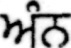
ਅੰਨ
